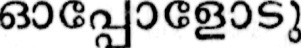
ഓപ്പോളോടു
